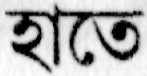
হাতে
